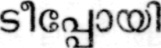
ടീപ്പോയി
